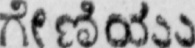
ಗೇಣಿಯು
